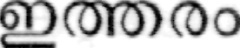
ഇത്തരം
